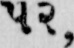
પર,
